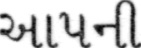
આપની
